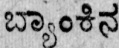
ಬ್ಯಾಂಕಿನ
